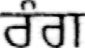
ਰੰਗ
